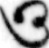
ও
